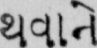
થવાને
